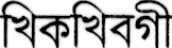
খিকখিবগী
